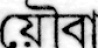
য়ৌবা
